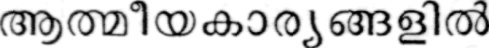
ആത്മീയകാര്യങ്ങളില്‍
